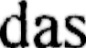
das
